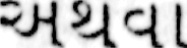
અથવા
